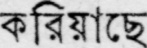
করিয়াছে
